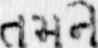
તમને
